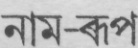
নাম-ৰূপ
